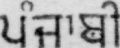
ਪੰਜਾਬੀ
